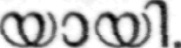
യായി.
